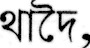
থাদৈ,
